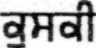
ਕੁਸਕੀ
